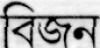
বিজন
